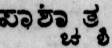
ಪಾಶ್ಚಾತ್ಯ
